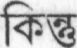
কিন্তু
